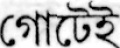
গোটেই
